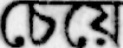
চেয়ে
